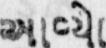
આવ્યો
